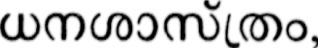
ധനശാസ്ത്രം,
